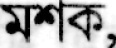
মশক,
